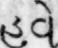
હવે
